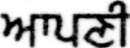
ਆਪਣੀ
